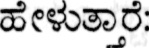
ಹೇಳುತ್ತಾರೆ:
